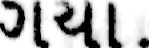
ગયા.
